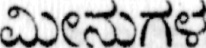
ಮೀನುಗಳ
